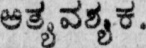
ಅತ್ಯವಶ್ಯಕ.
